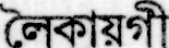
লৈকায়গী
